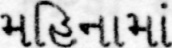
મહિનામાં
